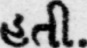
હતી.
